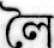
লৈ
